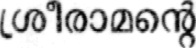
ശ്രീരാമന്റെ
